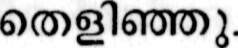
തെളിഞ്ഞു.
